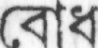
বোধ
